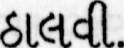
ઠાલવી.
